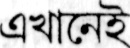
এখানেই
